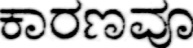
ಕಾರಣವೂ
